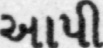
આપી
